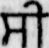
ਸੀ
